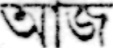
আজ
